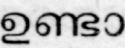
ഉണ്ടാ
